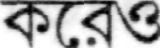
করেও
